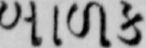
બાળક
